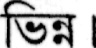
ভিন্ন।
